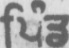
ਪਿੰਡ
